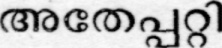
അതേപ്പറ്റി
